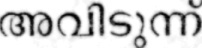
അവിടുന്ന്
